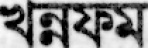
খন্নফম
